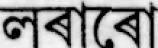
লৰাৰো
